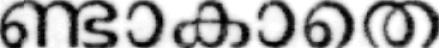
ണ്ടാകാതെ
